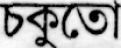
চকুতো
